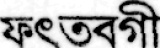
ফৎতবগী
